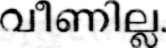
വീണില്ല.
